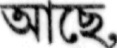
আছে,
